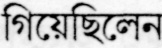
গিয়েছিলেন
